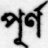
পূর্ণ
